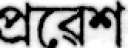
প্রৱেশ
